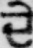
ਦੇ
